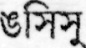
ঙসিসু
